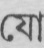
যো
